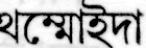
থম্মোইদা
